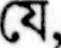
যে,
